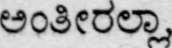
ಅಂತೀರಲ್ಲಾ,
